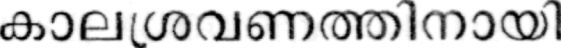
കാലശ്രവണത്തിനായി
